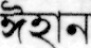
ঈহান
